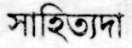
সাহিত্যদা
